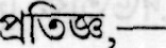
প্রতিজ্ঞ,-
